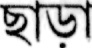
ছাড়া
